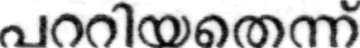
പററിയതെന്ന്
